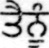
ਤੈਨੂੰ
